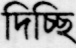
দিচ্ছি
